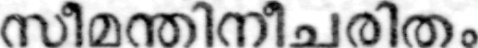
സീമന്തിനീചരിതം
